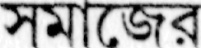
সমাজের
